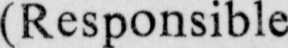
(Responsible
